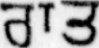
ਰਾਤ
